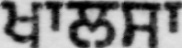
ਖਾਲਸਾ
